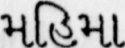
મહિમા
